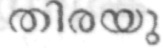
തിരയു
